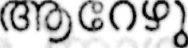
ആറേഴു
